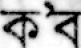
ক'ব
